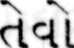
તેવો
